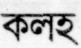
কলহ
